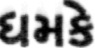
ધમકે
